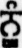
ਨੂੰ
